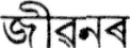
জীৱনৰ
